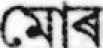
মোৰ
